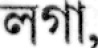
লগা,
